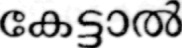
കേട്ടാല്‍
